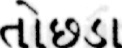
તોછડા
